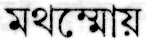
মথম্মোয়
